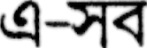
এ-সব
